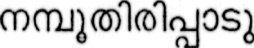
നമ്പൂതിരിപ്പാടു
